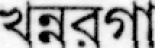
খন্নরগা
